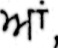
ਆਂ,
